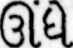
ઊંધે
